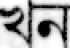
খন
